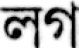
লগ
